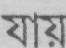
যায়
